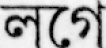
লগে
